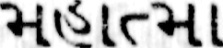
મહાત્મા
